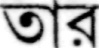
তার
